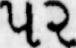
પર
